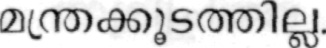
മന്ത്രക്കൂടത്തില്ല.
